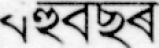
বহুবছৰ
